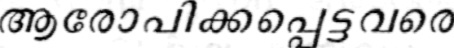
ആരോപിക്കപ്പെട്ടവരെ
